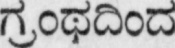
ಗ್ರಂಥದಿಂದ
